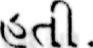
હતી.
